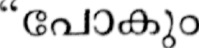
“പോകും
